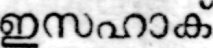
ഇസഹാക്
